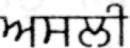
ਅਸਲੀ
